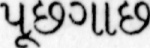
પૂછગાછ
